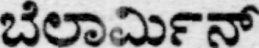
ಬೆಲಾರ್ಮಿನ್
